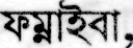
ফম্নাইবা,
